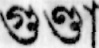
গুণ্ডা
